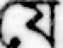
যে
